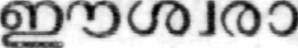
ഈശ്വരാ
